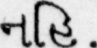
નહિ.
